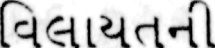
વિલાયતની
